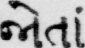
જોતાં
